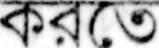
করতে
